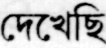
দেখেছি
